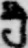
ਹੈ
